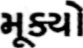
મૂક્યો
